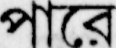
পারে
